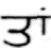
ਤਾਂ
